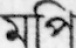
মপি
